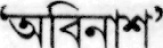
'অবিনাশ'
